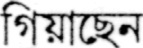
গিয়াছেন
